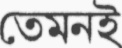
তেমনই
